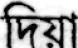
দিয়া
